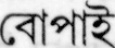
বোপাই
